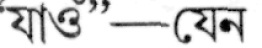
'যাওঁ"-যেন
